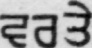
ਵਰਤੇ
